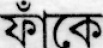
ফাঁকে
